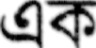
এক
